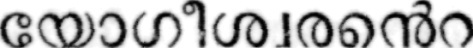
യോഗീശ്വരന്റെ
